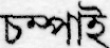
চম্পাই
